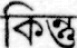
কিন্তু
